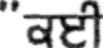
''ਕਈ
